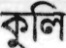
কুলি
